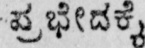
ಪ್ರಭೇದಕ್ಕೆ
